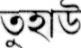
তুহাউ
